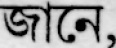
জানে,
